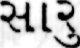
સારુ
